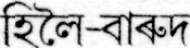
হিলৈ-বাৰুদ
